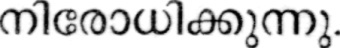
നിരോധിക്കുന്നു.
